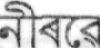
নীৰৱে
